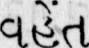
વહેંત
